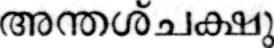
അന്തശ്ചക്ഷു
